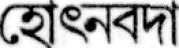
হোৎনবদা
